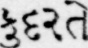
કુદરતે
